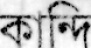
কান্দি
